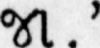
જા.'
